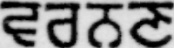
ਵਰਨਣ
